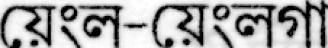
য়েংল-য়েংলগা
